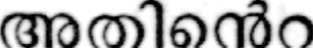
അതിന്റെ
